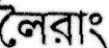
লৈরাং
